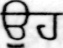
ਉਹ
